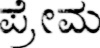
ಪ್ರೇಮ
